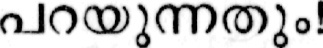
പറയുന്നതും!
